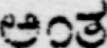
ಅಂತ
